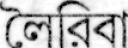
লৈরিবা
